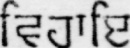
ਵਿਹਾਇ
